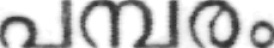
പമ്പരം
